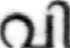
വി
